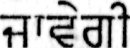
ਜਾਵੇਗੀ
